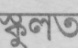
স্কুলত
